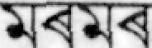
মৰমৰ
